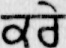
ਕਰੇ
